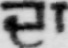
ਦਾ
